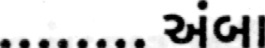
...........અંબા
